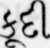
કૂદી
